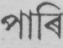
পাৰি
